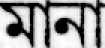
মানা
